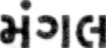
મંગલ
